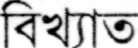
বিখ্যাত
